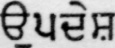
ਉਪਦੇਸ਼
